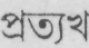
প্ৰত্যখ
